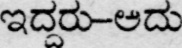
ಇದ್ದರು-ಅದು
